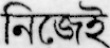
নিজেই
